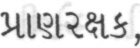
પ્રાણરક્ષક,
